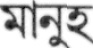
মানুহ
